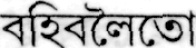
বহিবলৈতো
